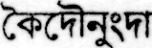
কৈদৌনুংদা
